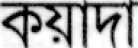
কয়াদা
